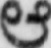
ಆ
